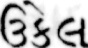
ઉકેલ
